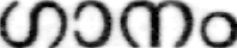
ഗാനം
